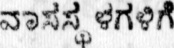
ವಾಸಸ್ಥಳಗಳಿಗೆ
